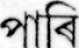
পাৰি
